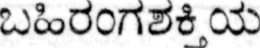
ಬಹಿರಂಗಶಕ್ತಿಯ
